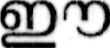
ഈ
